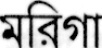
মরিগা
